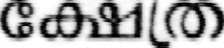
ക്ഷേത്ര
